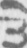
ਤੇ
